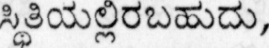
ಸ್ಥಿತಿಯಲ್ಲಿರಬಹುದು,
